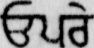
ਓਪਰੇ
